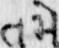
તમે
